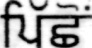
ਪਿੱਛੋਂ
